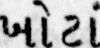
ખોટાં
